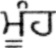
ਮੂੰਹ
